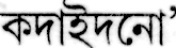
কদাইদনো’
